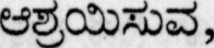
ಆಶ್ರಯಿಸುವ,
